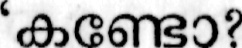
'കണ്ടോ?
